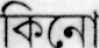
কিনো
